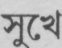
সুখে
